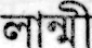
লান্মী
